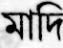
মাদি
